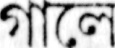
গালে
